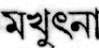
অদুগা
